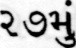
૨૭મું
